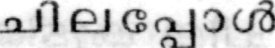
ചിലപ്പോള്‍
